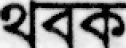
থবক
